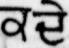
ਕਦੇ
